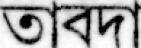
তাবদা
